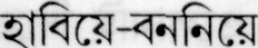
হাবিয়ে-বননিয়ে
